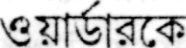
ওয়ার্ডারকে
